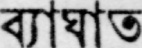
ব্যাঘাত
